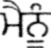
ਮੈਨੂੰ
